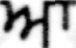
ਆ
